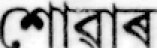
শোৱাৰ
